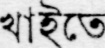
খাইতে
